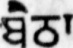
ਬੈਠਾ
